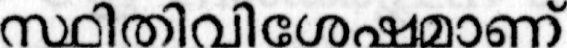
സ്ഥിതിവിശേഷമാണ്
